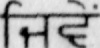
ਜਿਵੇਂ
